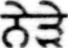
ਨੇੜੇ
